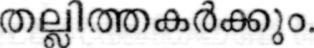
തല്ലിത്തകര്‍ക്കും.
